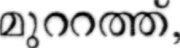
മുററത്ത്,
